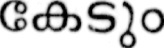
കേടും
